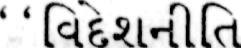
"વિદેશનીતિ
